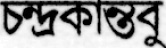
চন্দ্রকান্তবু
